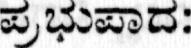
ಪ್ರಭುಪಾದ:
